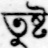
তুষ্ট
